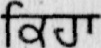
ਕਿਹਾ
